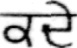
ਕਦੇ
